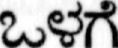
ಒಳಗೆ
